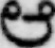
ಆ
